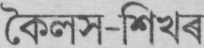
কৈলস-শিখৰ
